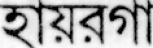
হায়রগা
